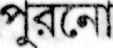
পুরনো
